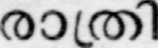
രാത്രി
